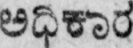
ಅಧಿಕಾರ
